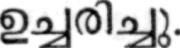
ഉച്ചരിച്ചു.
